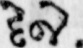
દેજે.
